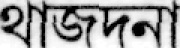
থাজদনা
